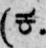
(ಕ.
